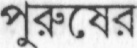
পুরুষের
